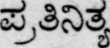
ಪ್ರತಿನಿತ್ಯ
